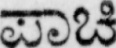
ಪಾಚಿ
